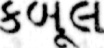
કબૂલ
